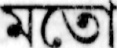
মতো
